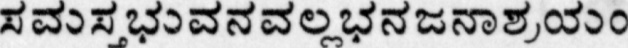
ಸಮಸ್ತಭುವನವಲ್ಲಭನಜನಾಶ್ರಯಂ
